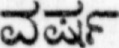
ವರ್ಷ
